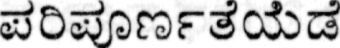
ಪರಿಪೂರ್ಣತೆಯೆಡೆ
